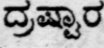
ದ್ರಷ್ಟಾರ
